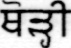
ਥੋੜ੍ਹੀ
